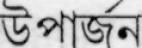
উপার্জন
